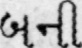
બની
